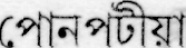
পোনপটীয়া
